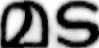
മട
